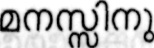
മനസ്സിനു
